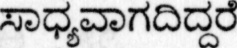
ಸಾಧ್ಯವಾಗದಿದ್ದರೆ
